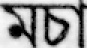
মচা
